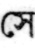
সে
